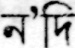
ন’দি
